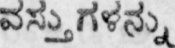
ವಸ್ತುಗಳನ್ನು
